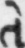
તે
